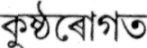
কুষ্ঠৰোগত
